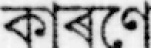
কাৰণে
